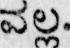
ವಲ್ಲ.
